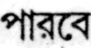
পারবে
